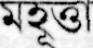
মহূত্তা
